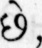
છે,
